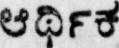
ಆರ್ಥಿಕ
